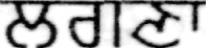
ਲਗਣਾ
